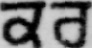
ਕਰ
